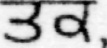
ਤਕ,
